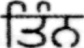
ਤਿੰਨ
